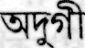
অদুগী
